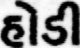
હોડી
